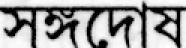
সঙ্গদোষ
